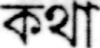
কথা
